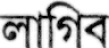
লাগিব
